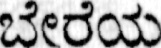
ಬೇರೆಯ
